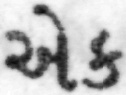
એક
